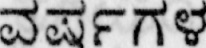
ವರ್ಷಗಳ
